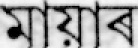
মায়াৰ
